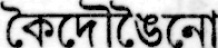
কৈদৌঙৈনো
